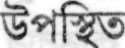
উপস্থিত
